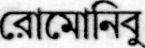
রোমোনিবু
